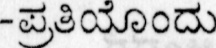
-ಪ್ರತಿಯೊಂದು
